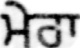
ਮੇਰਾ
